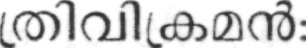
ത്രിവിക്രമന്‍:
